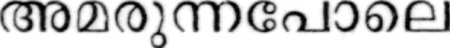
അമരുന്നപോലെ
